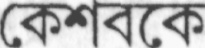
কেশবকে
